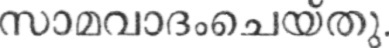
സാമവാദംചെയ്തു.
